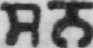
ਸਨ
